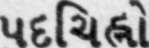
પદચિહ્નો
